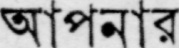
আপনার
